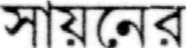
সায়নের
